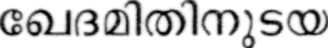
ഖേദമിതിനുടയ
